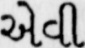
એવી
